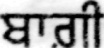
ਬਾਗ਼ੀ
